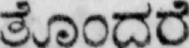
ತೊಂದರೆ
